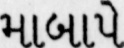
માબાપે
